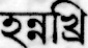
হন্নখ্রি
